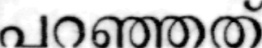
പറഞ്ഞത്
